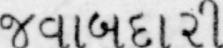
જવાબદારી
